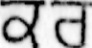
ਕਰ
